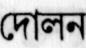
দোলন
